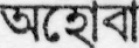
অহোবা
